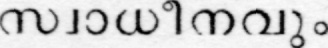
സ്വാധീനവും
